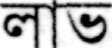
লাভ
